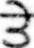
ਤੇ
